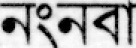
নংনবা
